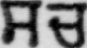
ਸਚ
